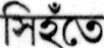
সিহঁতে
